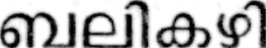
ബലികഴി
